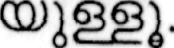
യുള്ളൂ.
